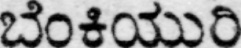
ಬೆಂಕಿಯುರಿ
